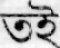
তই
